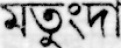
মতুংদা
